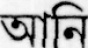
আনি
